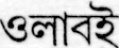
ওলাবই
